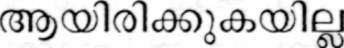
ആയിരിക്കുകയില്ല
